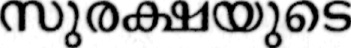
സുരക്ഷയുടെ
